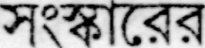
সংস্কারের
